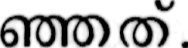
ഞ്ഞത്.
